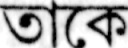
তাকে
